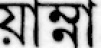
য়াম্না
